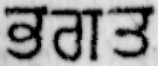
ਭਗਤ
